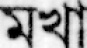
মখা
